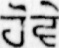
ਹੋਵੇ
